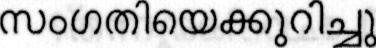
സംഗതിയെക്കുറിച്ചു
